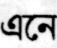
এনে
